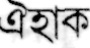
ঐহাক
